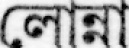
লোন্না
